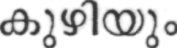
കുഴിയും
